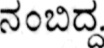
ನಂಬಿದ್ದ.
